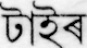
টাইৰ
